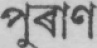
পুৰাণ
